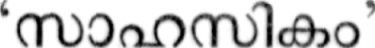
‘സാഹസികം’
